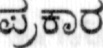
ಪ್ರಕಾರ
